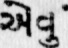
એવું
